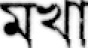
মখা
